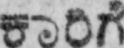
ಕಾರಿಗೆ
